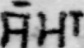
ਸੋਮਾ
